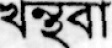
খন্থবা
